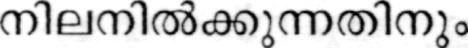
നിലനില്‍ക്കുന്നതിനും
